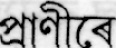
প্রাণীৰে
